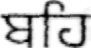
ਬਹਿ
